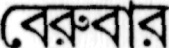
বেরুবার
